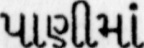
પાણીમાં
